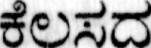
ಕೆಲಸದ
